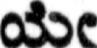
ಯೇ
